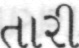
તારી
